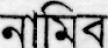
নামিব
